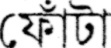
ফোঁটা
